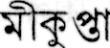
মীকুপ্তা
